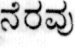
ನೆರವು
